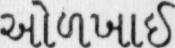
ઓળખાઈ
